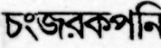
চংজরকপনি
